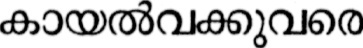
കായല്‍വക്കുവരെ
